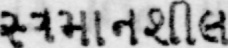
સ્વમાનશીલ
